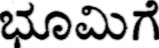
ಭೂಮಿಗೆ
